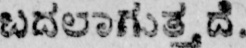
ಬದಲಾಗುತ್ತದೆ.
